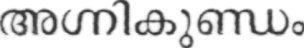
അഗ്നികുണ്ഡം
